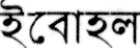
ইবোহল
